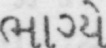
ભાગ્યે
